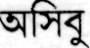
অসিবু
